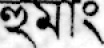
হুমাং
